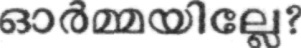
ഓര്‍മ്മയില്ലേ?
